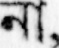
না,
